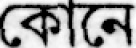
কোনে
